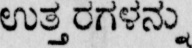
ಉತ್ತರಗಳನ್ನು
